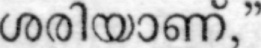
ശരിയാണ്,”
